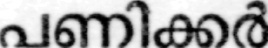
പണിക്കര്‍
